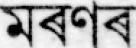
মৰণৰ
